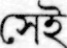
সেই
